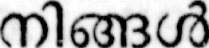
നിങ്ങള്‍
